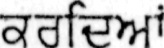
ਕਰਦਿਆਂ
